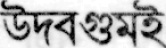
উদবগুমই
